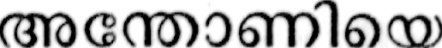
അന്തോണിയെ
